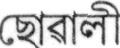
ছোৱালী
